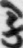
કે
